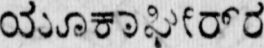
ಯೂಕಾಘೀರ್ರ
